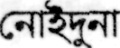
নোইদুনা
